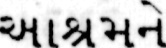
આશ્રમને
